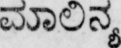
ಮಾಲಿನ್ಯ
